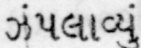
ઝંપલાવ્યું
